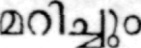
മറിച്ചും
